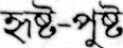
হৃষ্ট-পুষ্ট
